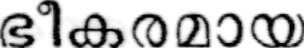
ഭീകരമായ
